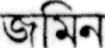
জমিন
